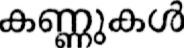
കണ്ണുകള്‍
